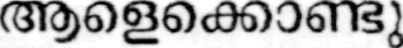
ആളെക്കൊണ്ടു
